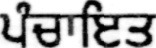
ਪੰਚਾਇਤ
